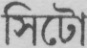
সিটো
